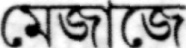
মেজাজে
